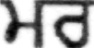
ਮਰ
